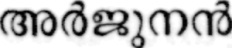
അര്‍ജുനന്‍
